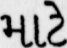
માટે
